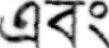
এবং
